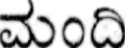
ಮಂದಿ
